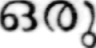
ഒരു
